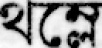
থম্লে
